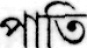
পাতি
